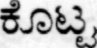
ಕೊಟ್ಟ
